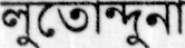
লুতোন্দা
